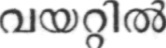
വയറ്റില്‍
